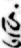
હું
